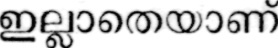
ഇല്ലാതെയാണ്
